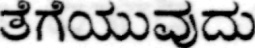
ತೆಗೆಯುವುದು
